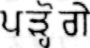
ਪੜ੍ਹੋਗੇ
